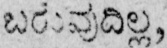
ಬರುವುದಿಲ್ಲ,
